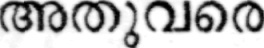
അതുവരെ
